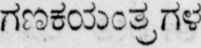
ಗಣಕಯಂತ್ರಗಳ
